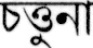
চত্তুনা
